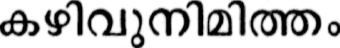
കഴിവുനിമിത്തം
